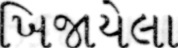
ખિજાયેલા
